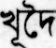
খূদৈ
